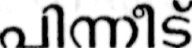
പിന്നീട്
